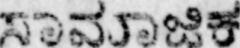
ಸಾಮಾಜಿಕ
